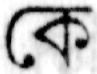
কে
